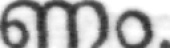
ണം.
